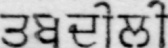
ਤਬਦੀਲੀ
